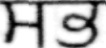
ਸਭ
